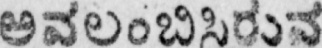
ಅವಲಂಬಿಸಿರುವ
